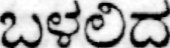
ಬಳಲಿದ
